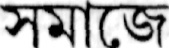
সমাজে
